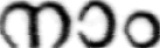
നാം
